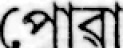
পোৱা
